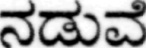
ನಡುವೆ
